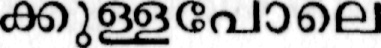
ക്കുള്ളപോലെ
